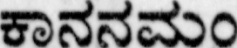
ಕಾನನಮಂ
